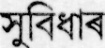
সুবিধাৰ
